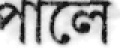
পালে
